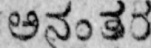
ಅನಂತರ
